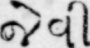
જેવી
